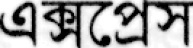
এক্সপ্রেস
